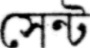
সেন্ট
